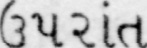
ઉપરાંત
